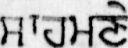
ਸਾਹਮਣੇ
